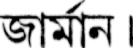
জার্মান।
